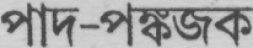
পাদ-পঙ্কজক
